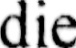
die
